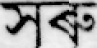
সৰু
